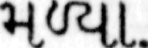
મળ્યા.
